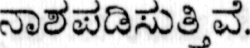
ನಾಶಪಡಿಸುತ್ತಿವೆ.
